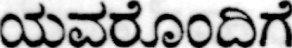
ಯವರೊಂದಿಗೆ
